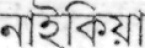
নাইকিয়া
